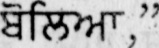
ਬੋਲਿਆ,''
